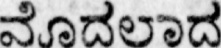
ಮೊದಲಾದ
